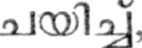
ചയിച്ച്,
